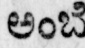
ಅಂಬೆ
